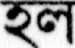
হল
